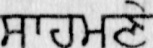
ਸਾਹਮਣੇ
